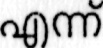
എന്ന്
